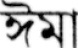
ঈমা
